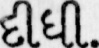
દીધી.
